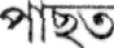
পাছত
